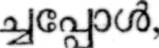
ച്ചപ്പോള്‍,
